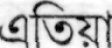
এতিয়া
